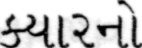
ક્યારનો
